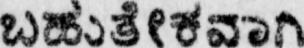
ಬಹುತೇಕವಾಗಿ
